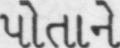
પોતાને
